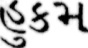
હુકમ
